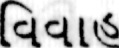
વિવાહ
